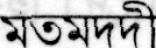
মতমদদী
